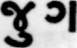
જુગ
